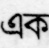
এক
